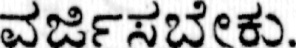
ವರ್ಜಿಸಬೇಕು.
